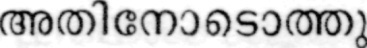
അതിനോടൊത്തു
